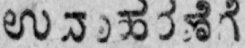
ಉದಾಹರಣೆಗೆ
